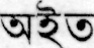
অইত
